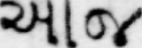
આજ
